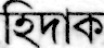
হিদাক
